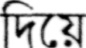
দিয়ে
